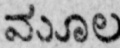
ಮೂಲ
